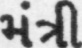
મંત્રી
